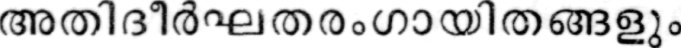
അതിദീര്‍ഘതരംഗായിതങ്ങളും
